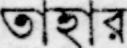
তাহার
